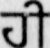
ਹੀ
